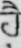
ਹੈ
